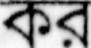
কর
